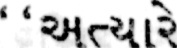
"અત્યારે
